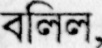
বলিল,
